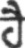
ਹੈ
